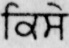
ਕਿਸੇ
